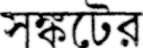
সঙ্কটের
